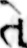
તે
